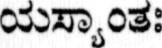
ಯಸ್ಯಾಂತಃ
